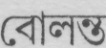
বোলন্ত
